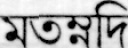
মতম্নদি
